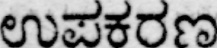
ಉಪಕರಣ
